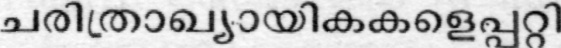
ചരിത്രാഖ്യായികകളെപ്പറ്റി
